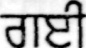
ਗਈ
